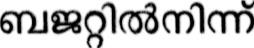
ബജറ്റില്‍നിന്ന്
